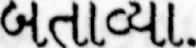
બતાવ્યા.
